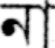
না
